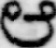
ಆ
